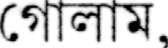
গোলাম,
